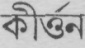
কীৰ্ত্তন
